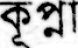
কূপ্না
